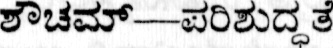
ಶೌಚಮ್-ಪರಿಶುದ್ಧತೆ
